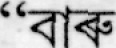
"বাৰু
